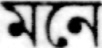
মনে
